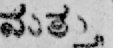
ಮತ್ತು
